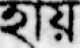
হায়
